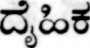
ದೈಹಿಕ
